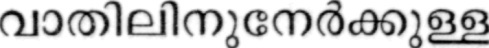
വാതിലിനുനേര്‍ക്കുള്ള
